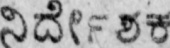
ನಿರ್ದೇಶಕ
